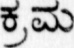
ಕ್ರಮ
